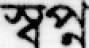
স্বপ্ন
